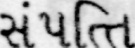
સંપત્તિ
